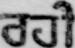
ਰਹੀ
